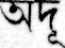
অদূ
